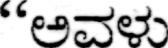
"ಅವಳು
